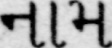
નામ
